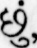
છું,
